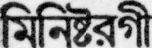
মিনিষ্টরগী
